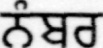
ਨੰਬਰ
